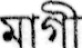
মাগী
